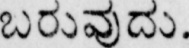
ಬರುವುದು.
